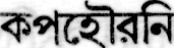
কপহৌরনি
